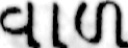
વાળ
